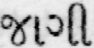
જાગી
